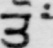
ਤੋਂ
